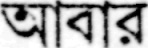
আবার
